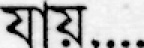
যায়....
